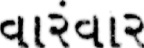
વારંવાર
